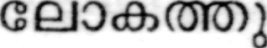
ലോകത്തു
